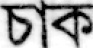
চাক
